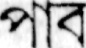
পাব
